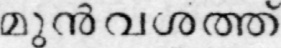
മുന്‍വശത്ത്
